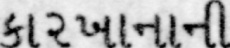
કારખાનાની
